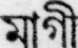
মাগী
